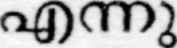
എന്നു
